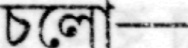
চলো—
